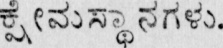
ಕ್ಷೇಮಸ್ಥಾನಗಳು.
